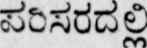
ಪರಿಸರದಲ್ಲಿ
